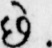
છે.
